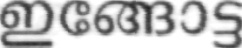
ഇങ്ങോട്ട
